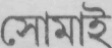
সোমাই
